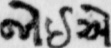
જોઈએ
